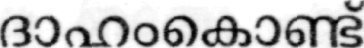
ദാഹംകൊണ്ട്
